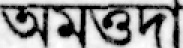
অমত্তদা
